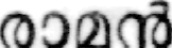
രാമന്‍
